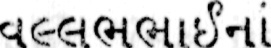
વલ્લભભાઈનાં
